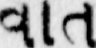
વાત
